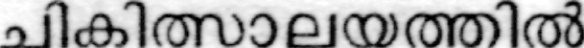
ചികിത്സാലയത്തില്‍
